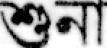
শুনা
